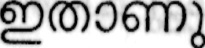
ഇതാണു
